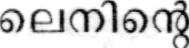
ലെനിന്റെ
